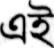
এই
